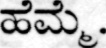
ಹೆಮ್ಮೆ.
